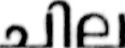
ചില
